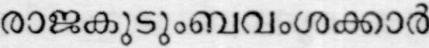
രാജകുടുംബവംശക്കാര്‍
